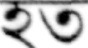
হত
